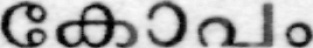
കോപം
